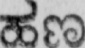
ಹಣ
